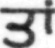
ਤਾਂ
